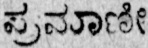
ಪ್ರಮಾಣೀ
